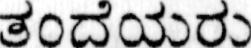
ತಂದೆಯರು
